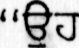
''ਉਹ
